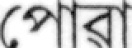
পোৱা
